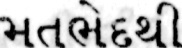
મતભેદથી
